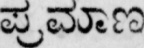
ಪ್ರಮಾಣ
